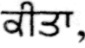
ਕੀਤਾ,
